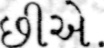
છીએ.
